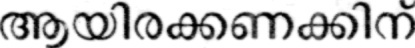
ആയിരക്കണക്കിന്
